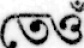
তেওঁ
